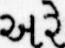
અરે
